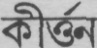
কীৰ্ত্তন
